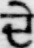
ਦੇ
